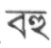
বহু
